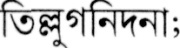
তিল্লুগনিদনা;
